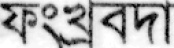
ফংখ্রবদা
